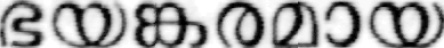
ഭയങ്കരമായ
